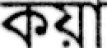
কয়া
